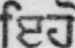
ਇਹੋ
